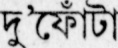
দু'ফোঁটা
